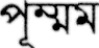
পূম্মম
